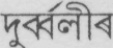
দুৰ্ব্বলীৰ
